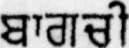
ਬਾਗਚੀ
